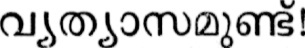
വ്യത്യാസമുണ്ട്!
